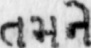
તમને
